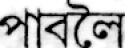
পাবলৈ
